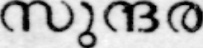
സുന്ദര
